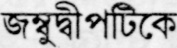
জম্বুদ্বীপটিকে
